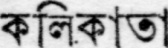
কলিকাতা
